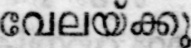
വേലയ്ക്കു
